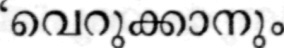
'വെറുക്കാനും
